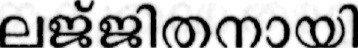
ലജ്ജിതനായി
